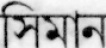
সিমান
